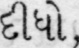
દીધો,
